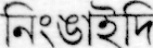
নিংঙাইদি
